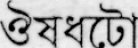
ঔষধটো
